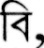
বি,
